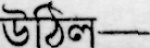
উঠিল-
